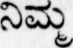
ನಿಮ್ಮ
